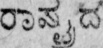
ರಾಷ್ಟ್ರದ
